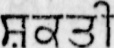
ਸ਼ਕਤੀ
